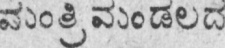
ಮಂತ್ರಿಮಂಡಲದ
